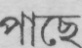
পাছে
